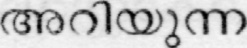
അറിയുന്ന
